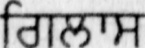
ਗਿਲਾਸ
